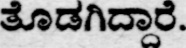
ತೊಡಗಿದ್ದಾರೆ.
